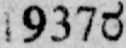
1937ರ
